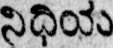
ನಿಧಿಯ
